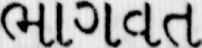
ભાગવત
